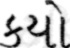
કયો
